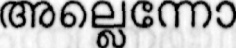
അല്ലെന്നോ
